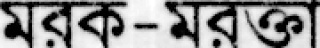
মরক-মরক্তা
